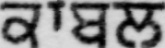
ਕਾਬਲ
